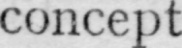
concept
